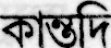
কান্তদি
